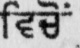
ਵਿਚੋਂ
